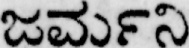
ಜರ್ಮನಿ
